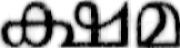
ക്ഷമ
